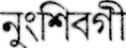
নুংশিবগী
